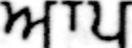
ਆਪ
